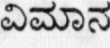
ವಿಮಾನ
